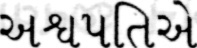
અશ્વપતિએ
